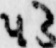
પડે
